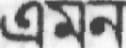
এমন
